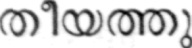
തീയത്തു
